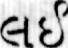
લઈ
